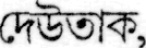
দেউতাক,
